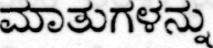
ಮಾತುಗಳನ್ನು
